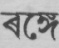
ৰঙ্গে
